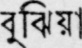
বুঝিয়া
